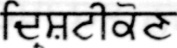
ਦ੍ਰਿਸ਼ਟੀਕੋਣ
